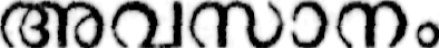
അവസാനം
